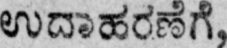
ಉದಾಹರಣೆಗೆ,
